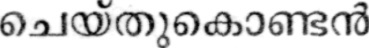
ചെയ്തുകൊണ്ടന്‍
